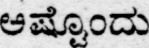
ಅಷ್ಟೊಂದು
